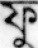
ফু
